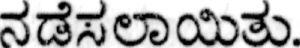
ನಡೆಸಲಾಯಿತು.
